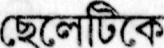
ছেলেটিকে
